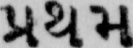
પ્રથમ
